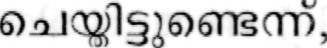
ചെയ്തിട്ടുണ്ടെന്ന്,
